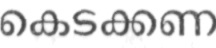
കെടക്കണ
